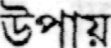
উপায়
